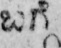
ಬಗ್ಗೆ
